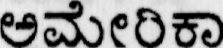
ಅಮೇರಿಕಾ
